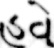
હવે
